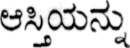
ಆಸ್ತಿಯನ್ನು
